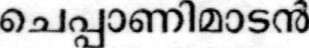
ചെപ്പാണിമാടന്‍
